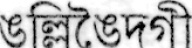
ঙল্লিঙৈদগী
